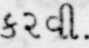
કરવી.
